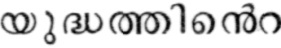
യുദ്ധത്തിന്റെ
